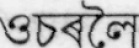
ওচৰলৈ
